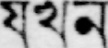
যখন
